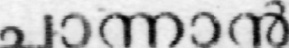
ചാന്നാന്‍
